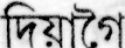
দিয়াগৈ
